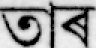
তাৰ
